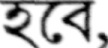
হবে,
